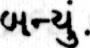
બન્યું.
